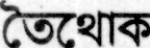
তৈথোক
